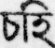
চহি
